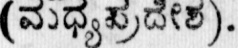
(ಮಧ್ಯಪ್ರದೇಶ).
